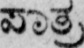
ಪಾತ್ರ
